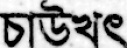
চাউখৎ
